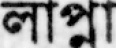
লাপ্না
